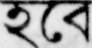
হবে
